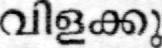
വിളക്കു
